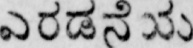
ಎರಡನೆಯ
